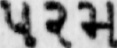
પરમ
